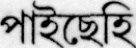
পাইছেহি
